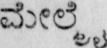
ಮೇಲ್ಮೈ
